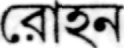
রোহন
